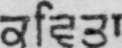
ਕਵਿਤਾ
